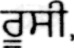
ਰੂਸੀ,
